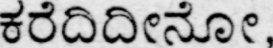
ಕರೆದಿದೀನೋ,
